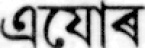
এযোৰ
